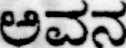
ಅವನ
